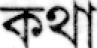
কথা
